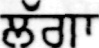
ਲੱਗਾ
